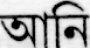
আনি
